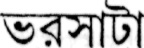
ভরসাটা
